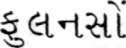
ફુલનસોં
